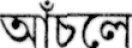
আঁচলে
